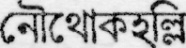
নৌথোকহল্লি
